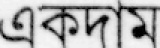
একদাম
